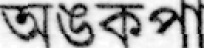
অঙকপা
